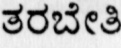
ತರಬೇತಿ
